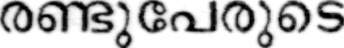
രണ്ടുപേരുടെ
